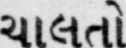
ચાલતો
